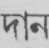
দান
